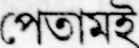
পেতামই
